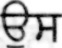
ਉਸ
